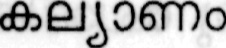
കല്യാണം
